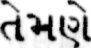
તેમણે
